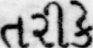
તરીકે
